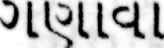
ગણાવા
